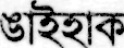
ঙাইহাক
